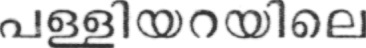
പള്ളിയറയിലെ
